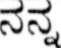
ನನ್ನ
